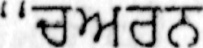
''ਚਅਰਨ
